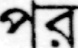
পর
